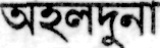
অহলদুনা
